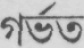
গৰ্ভত
